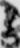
કે
